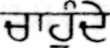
ਚਾਹੁੰਦੇ
